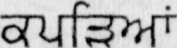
ਕਪੜਿਆਂ
